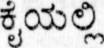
ಕೈಯಲ್ಲಿ
